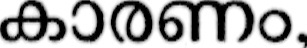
കാരണം,
